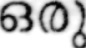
ഒരു
